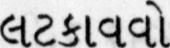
લટકાવવો
